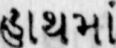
હાથમાં
